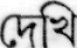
দেখি
